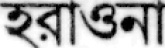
হরাওনা
